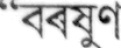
"বৰষুণ
